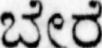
ಬೇರೆ
